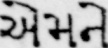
એમને
